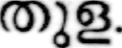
തുള.
